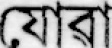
যোৱা
